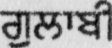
ਗੁਲਾਬੀ
